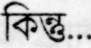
কিন্তু...
